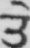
ਤੇ
